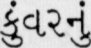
કુંવરનું
